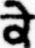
ਕੇ
